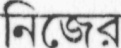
নিজের
